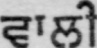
ਵਾਲੀ
